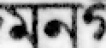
মনগ
